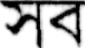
সব
